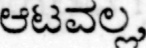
ಆಟವಲ್ಲ,
